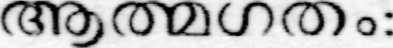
ആത്മഗതം:
